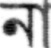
না
